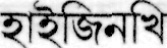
হাইজিনখি
